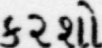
કરશો
